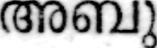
അബു
